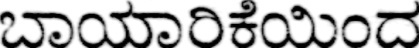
ಬಾಯಾರಿಕೆಯಿಂದ
